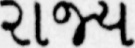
રાજ્ય
